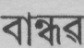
বান্ধৱ
